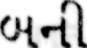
બની
